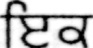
ਇਕ
